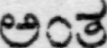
ಅ೦ತ
